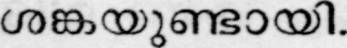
ശങ്കയുണ്ടായി.
